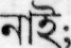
নাই;
